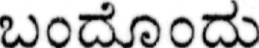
ಬಂದೊಂದು
